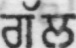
ਗੱਲ
